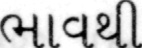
ભાવથી
